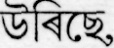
উৰিছে,
